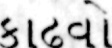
કાઢવો
